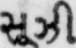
સૂઝી
